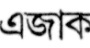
এজাক
